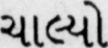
ચાલ્યો
